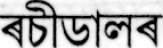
ৰচীডালৰ
